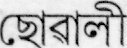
ছোৱালী
